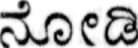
ನೋಡಿ
